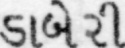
ડાબેરી
